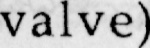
valve)
